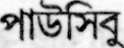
পাউসিবু
